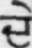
ਦੇ
